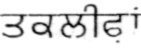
ਤਕਲੀਫ਼ਾਂ
